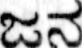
ಜನ
